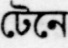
টেনে
